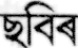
ছবিৰ
